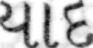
યાદ
